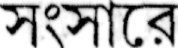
সংসারে
